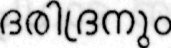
ദരിദ്രനും
